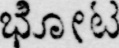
ಭೋಟ
